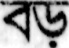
বড়
